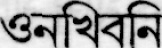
ওনখিবনি
